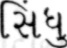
સિંધુ
